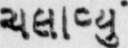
ચલાવ્યું
